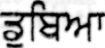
ਡੁਬਿਆ
